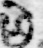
છે.
